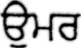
ਉਮਰ
